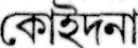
কোইদনা
